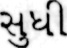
સુધી
